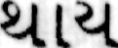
થાય
